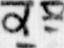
ਕੁਝ
